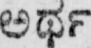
ಅರ್ಥ
